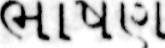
ભાષણ
